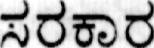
ಸರಕಾರ
